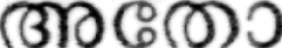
അതോ
